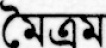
মৈত্রম
